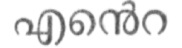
എന്റെ
